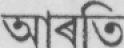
আৰতি
